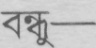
বন্ধু-
